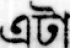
এটা
